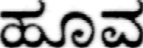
ಹೂವ
